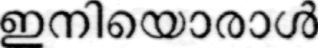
ഇനിയൊരാള്‍
